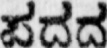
ಪದದ
